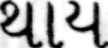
થાય
